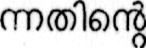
ന്നതിന്റെ
